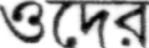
ওদের
